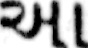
આ
